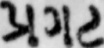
પ્રગટ
